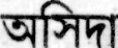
অমগীদমক
